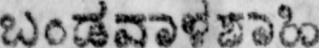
ಬಂಡವಾಳಶಾಹಿ
